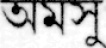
অমসু
